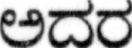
ಅದರ
